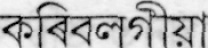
কৰিবলগীয়া
